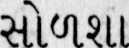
સોળશા
